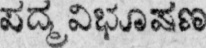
ಪದ್ಮವಿಭೂಷಣ
